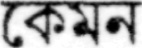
কেমন
